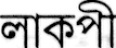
লাকপী
